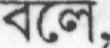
বলে,
